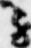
કે
